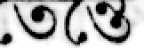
তেন্তে
